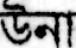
উনা
